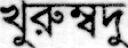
খুরুম্বদু
